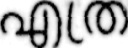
എത്ര
